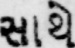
સાથે
